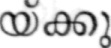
യ്ക്കു
